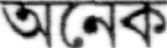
অনেক
